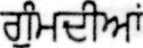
ਗੁੰਮਦੀਆਂ
